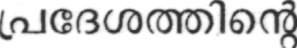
പ്രദേശത്തിന്റെ
